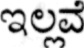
ಇಲ್ಲವೆ
